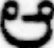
ಆ
